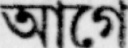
আগে
